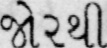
જોરથી
